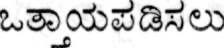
ಒತ್ತಾಯಪಡಿಸಲು
